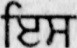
ਇਸ
